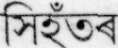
সিহঁতৰ
